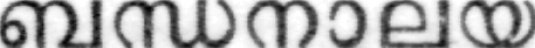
ബന്ധനാലയ
